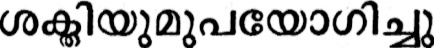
ശക്തിയുമുപയോഗിച്ചു
